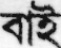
বাই
